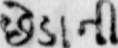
છેડાની
